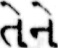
તેને
